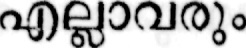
എല്ലാവരും
